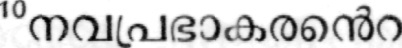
10നവപ്രഭാകരന്റെ
